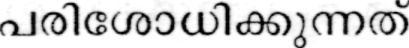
പരിശോധിക്കുന്നത്
